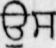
ਉਸ
